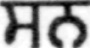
ਸਨ
